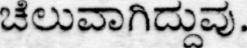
ಚೆಲುವಾಗಿದ್ದುವು.
